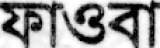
ফাওবা
